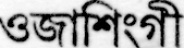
ওজাশিংগী
